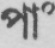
পা
